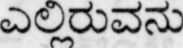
ಎಲ್ಲಿರುವನು
